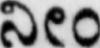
ನೀಂ
